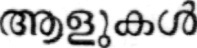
ആളുകള്‍
